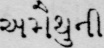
અમૈથુની
